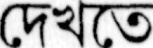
দেখতে
